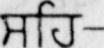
ਸਹਿ-
